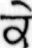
ਕੇ
